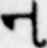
ન
